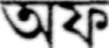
অফ
